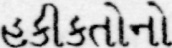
હકીકતોનો
